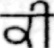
ਕੀ
